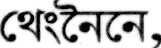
থেংনৈনে
